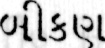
બીકણ
